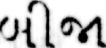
બીજા
